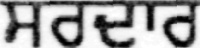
ਸਰਦਾਰ
